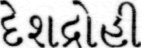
દેશદ્રોહી
